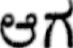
ಆಗ
